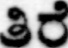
ತಿರೆ
